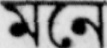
মনে
